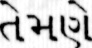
તેમણે
